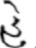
હે
